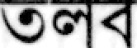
তলব
